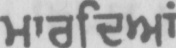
ਮਾਰਦਿਆਂ
